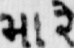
મારે
